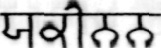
ਯਕੀਨਨ
